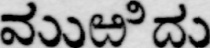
ಮುಱಿದು
